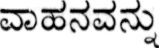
ವಾಹನವನ್ನು
